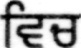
ਵਿਚ
